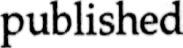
published
